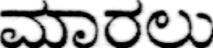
ಮಾರಲು
